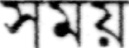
সময়
